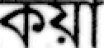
কয়া
